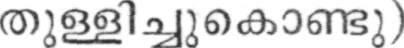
തുള്ളിച്ചുകൊണ്ടു)
